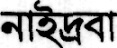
নাইদ্রবা
